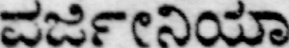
ವರ್ಜೀನಿಯಾ
